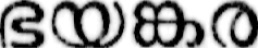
ഭയങ്കര
